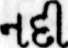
નદી
